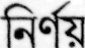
নির্ণয়
